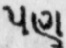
પણ
